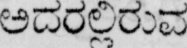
ಅದರಲ್ಲಿರುವ
